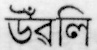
উঁৱলি
